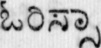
ಓರಿಸ್ಸಾ
